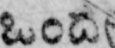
ಒಂದೇ
